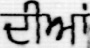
ਦੀਆਂ
